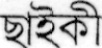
ছাইকী
